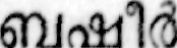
ബഷീര്‍
